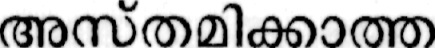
അസ്തമിക്കാത്ത
